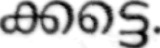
ക്കട്ടെ.
